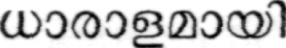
ധാരാളമായി
